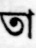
তা
